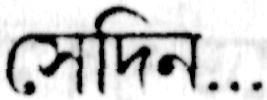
সেদিন...
